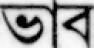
ভাব
